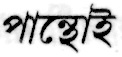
পান্থোই
